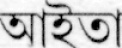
আইতা
